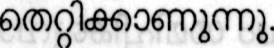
തെറ്റിക്കാണുന്നു.
